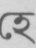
হে
